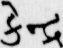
કેન્દ્ર
